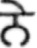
ਨੇ
